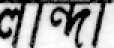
লান্দা
